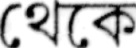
থেকে
